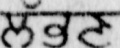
ਲੱਭਣ
